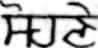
ਸੋਹਣੇ
